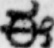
ಈ
